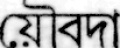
য়ৌবদা
